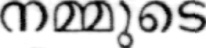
നമ്മുടെ
